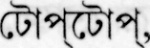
টোপটোপ্‌,
